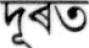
দূৰত
